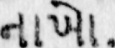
નાખો.
